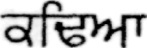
ਕਢਿਆ
